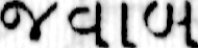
જવાબ
